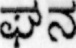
ಘನ
